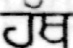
ਹੱਥ
